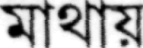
মাথায়
